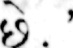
છે.'
